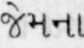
જેમના
